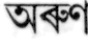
অৰুণ
